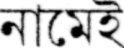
নামেই
